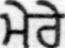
ਮੇਰੇ
